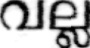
വല്ല
